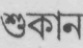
শুকান
